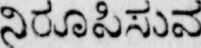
ನಿರೂಪಿಸುವ
